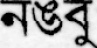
নঙবু
